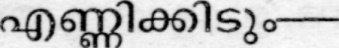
എണ്ണിക്കിടും-
